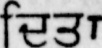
ਦਿਤਾ
